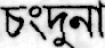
চংদুনা
